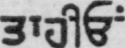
ਤਾਹੀਓਂ
